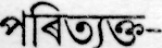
পৰিত্যক্ত-
